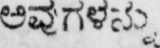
ಅವುಗಳನ್ನು
